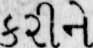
કરીને
